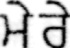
ਮੇਰੇ
